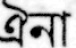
ঐনা
